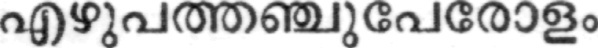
എഴുപത്തഞ്ചുപേരോളം
